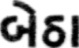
બેઠા
